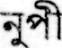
নুপী
